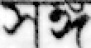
সঙ্গ
